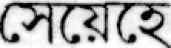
সেয়েহে
